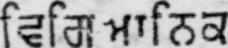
ਵਿਗਿਆਨਿਕ
